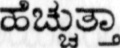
ಹೆಚ್ಚುತ್ತಾ
